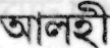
আলহী
